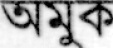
অমুক
